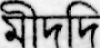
মীদদি
